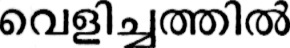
വെളിച്ചത്തില്‍
